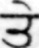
ਤੇ
